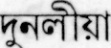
দুনলীয়া
